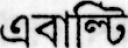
এবাল্টি
